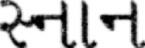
સ્નાન
